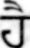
ਹੈ
